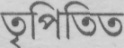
তৃপিতিত
